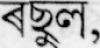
ৰছুল,
